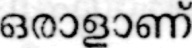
ഒരാളാണ്
